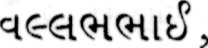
વલ્લભભાઈ,
